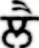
ਲੈ
